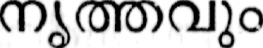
നൃത്തവും
